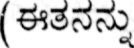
(ಈತನನ್ನು
